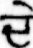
ਦੇ
